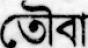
তৌবা
